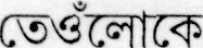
তেওঁলোকে
